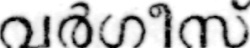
വര്‍ഗീസ്
